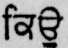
ਕਿਉਂ
